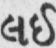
લઈ
